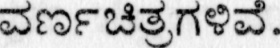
ವರ್ಣಚಿತ್ರಗಳಿವೆ.
